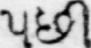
પછી
